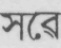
সৱে
